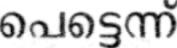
പെട്ടെന്ന്
